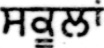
ਸਕੂਲਾਂ
